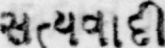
સત્યવાદી
